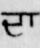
ਦਾ
